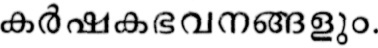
കര്‍ഷകഭവനങ്ങളും.
